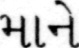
માને
